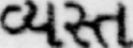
વ્યસ્ત
